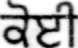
ਕੋਈ
